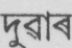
দুৱাৰ
